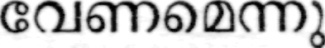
വേണമെന്നു
